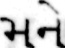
મને
